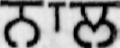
ਨਾਲ
